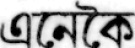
এনেকৈ
